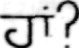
ਹਾਂ?
